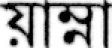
য়াম্না
